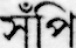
সঁপি
